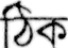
ঠিক
